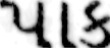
પાક
